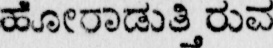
ಹೋರಾಡುತ್ತಿರುವ
